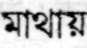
মাথায়
